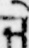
ਜੇ
